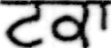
ਟਕਾ
